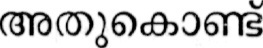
അതുകൊണ്ട്
